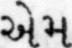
એમ
